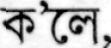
ক'লে,
